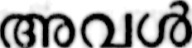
അവള്‍
